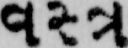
વસ્ત્ર
